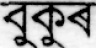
বুকুৰ
